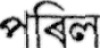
পৰিল
